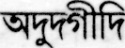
অদুদগীদি
